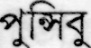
পুন্সিবু
